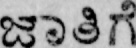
ಜಾತಿಗೆ
